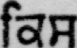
ਕਿਸ
